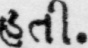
હતી.
